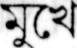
মুখে
